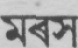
মৰস
